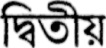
দ্বিতীয়
